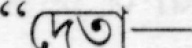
"দেতা-
